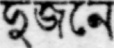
দুজনে
